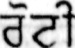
ਰੋਟੀ
